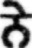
ਨੇ
